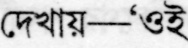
দেখায়–‘ওই
